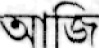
আজি
